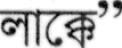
লাক্কে”
